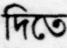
দিতে
